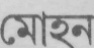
মোহন
